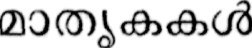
മാതൃകകള്‍
